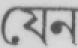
যেন
